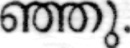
ഞ്ഞു.
